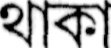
থাকা
